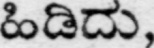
ಹಿಡಿದು,
